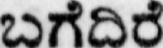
ಬಗೆದಿರೆ
